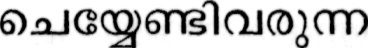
ചെയ്യേണ്ടിവരുന്ന
